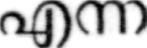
എന്ന
